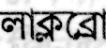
লাক্লব্রো
